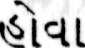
હોવા
